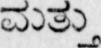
ಮತ್ತು
